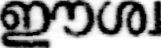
ഈശ്വ
